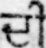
ਦੀ
